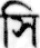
সি
